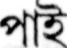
পাই
